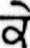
ਕੇ
